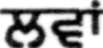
ਲਵਾਂ
